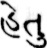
હેતુ
